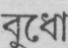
বুধো
